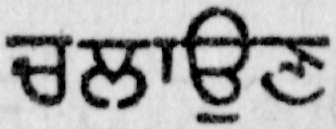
ਚਲਾਉਣ
